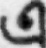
এ
